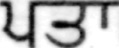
ਪਤਾ
